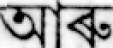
আৰু
